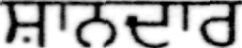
ਸ਼ਾਨਦਾਰ
